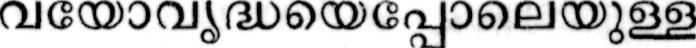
വയോവൃദ്ധയെപ്പോലെയുള്ള
